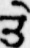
ਤੇ
